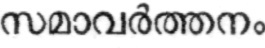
സമാവര്‍ത്തനം
